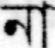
না
